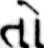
તો
